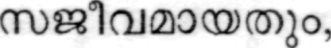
സജീവമായതും,
